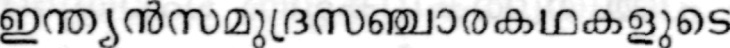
ഇന്ത്യന്‍സമുദ്രസഞ്ചാരകഥകളുടെ
